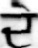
ਦੇ
